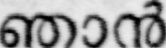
ഞാന്‍
